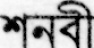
শনবী
